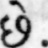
છે.
